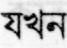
যখন
